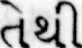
તેથી
